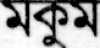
মকুম
